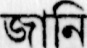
জানি
